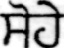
ਸੋਹੇ
